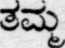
ತಮ್ಮ
